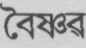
বৈষ্ণৱ
